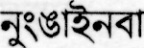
নুংঙাইনবা
